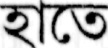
হাতে
